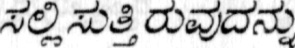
ಸಲ್ಲಿಸುತ್ತಿರುವುದನ್ನು
